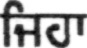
ਜਿਹਾ
